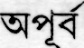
অপূর্ব
